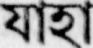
যাহা
